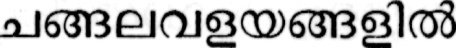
ചങ്ങലവളയങ്ങളില്‍
